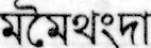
মমৈথংদা
